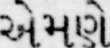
એમણે
